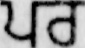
ਪਰ
